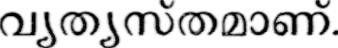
വ്യത്യസ്തമാണ്.
